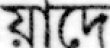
য়াদে
